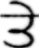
ਤੇ
